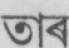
তাৰ
